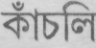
কাঁচলি
